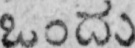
ಒಂದು
